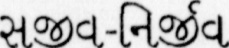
સજીવ-નિર્જીવ
